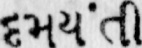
દમયંતી
